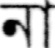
না
